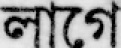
লাগে
